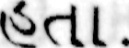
હતા.
